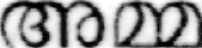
അമ്മ
